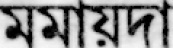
মমায়দা
